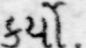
કર્યો.
